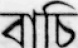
বাচি
